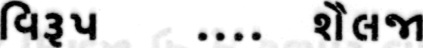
વિરૂપ....શૈલજા
